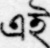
এই
